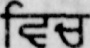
ਵਿਚ
